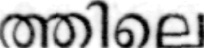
ത്തിലെ
